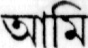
আমি
